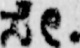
ಸೇ.
